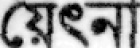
য়েৎনা
